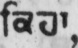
ਕਿਹਾ,
